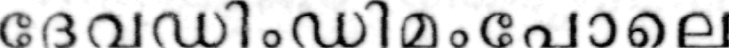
ദേവഡിംഡിമംപോലെ
